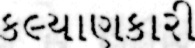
કલ્યાણકારી
